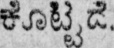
ಕೊಟ್ಟಿದೆ.
